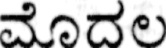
ಮೊದಲ
